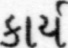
કાર્ય
